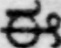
ಈ
